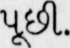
પૂછી.
